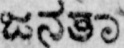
ಜನತಾ
